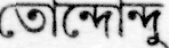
তোন্দোন্দু
